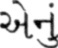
એનું
